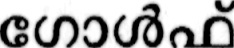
ഗോള്‍ഫ്
